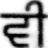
ਵੀ
